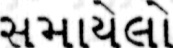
સમાયેલો
